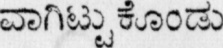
ವಾಗಿಟ್ಟುಕೊಂಡು
